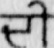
ਦੀ
